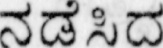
ನಡೆಸಿದ
